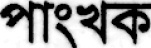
পাংখক
